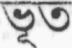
ভূত
